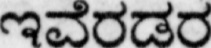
ಇವೆರಡರ
